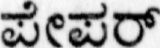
ಪೇಪರ್
